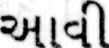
આવી
